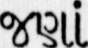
જણાં
